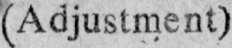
(Adjustment)
